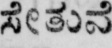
ಸೇತುವೆ
